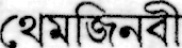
থেমজিনবী
